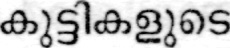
കുട്ടികളുടെ
